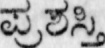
ಪ್ರಶಸ್ತಿ
